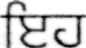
ਇਹ
